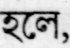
হলে,
